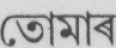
তোমাৰ
